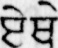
ਏਥੇ
